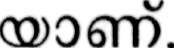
യാണ്.
